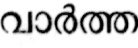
വാര്‍ത്ത
